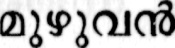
മുഴുവന്‍
